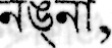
নঙ্না,
